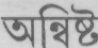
অন্বিষ্ট
